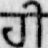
ਹੀ
